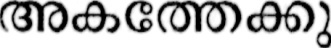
അകത്തേക്കു
